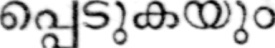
പ്പെടുകയും
